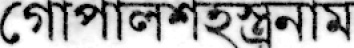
গোপালশহস্ত্রনাম
